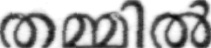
തമ്മില്‍
